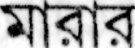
মারার
